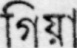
গিয়া
